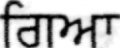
ਗਿਆ
